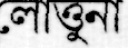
লোত্তুনা
